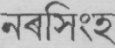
নৰসিংহ
